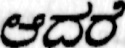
ಆದರೆ
